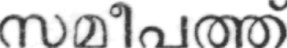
സമീപത്ത്
